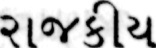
રાજકીય
